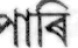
পাৰি
